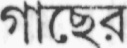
গাছের
